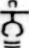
ਨੂੰ
